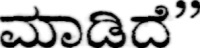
ಮಾಡಿದೆ"
